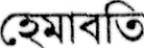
হেমাবতি
